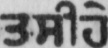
ਤਸੀਹੇ
